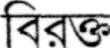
বিরক্ত
